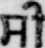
ਸੀ
